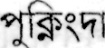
পুক্নিংদা
